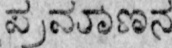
ಪ್ರಮಾಣನ
